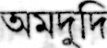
অমদুদি
